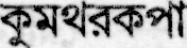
কুমথরকপা
